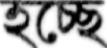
হচ্ছে
